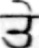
ਤੇ
